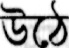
উঠে
